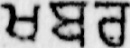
ਖਬਰ
